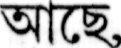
আছে,
